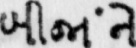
બીજાં
